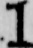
I
